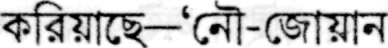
করিয়াছে—‘নৌ-জোয়ান
